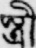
স্ত্রী
